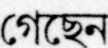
গেছেন
